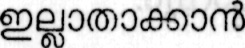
ഇല്ലാതാക്കാന്‍
